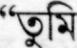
"তুমি
